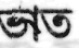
ভাত
